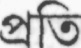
প্রতি
